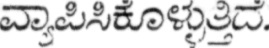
ವ್ಯಾಪಿಸಿಕೊಳ್ಳುತ್ತಿದೆ.
